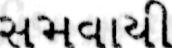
સમવાયી
